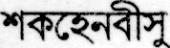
শকহেনবীসু
